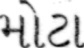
મોટા
